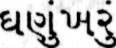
ઘણુંખરું
